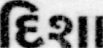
દિશા
